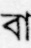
বা
